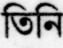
তিনি
